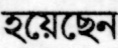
হয়েছেন
